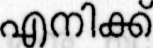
എനിക്ക്
